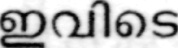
ഇവിടെ
